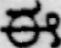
ಈ
